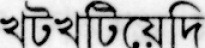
খটখটিয়েদি
